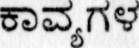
ಕಾವ್ಯಗಳ
